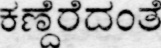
ಕಣ್ದೆರೆದಂತೆ
